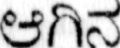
ಆಗಿನ
